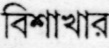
বিশাখার
